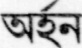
অর্হন
